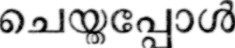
ചെയ്തപ്പോള്‍
